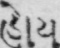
હોય
